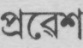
প্ৰৱেশ
